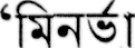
‘মিনর্ভা
